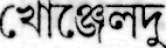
খোঞ্জেলদু
